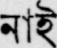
নাই
